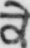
ਕੇ
